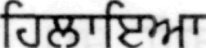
ਹਿਲਾਇਆ
